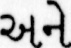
અને
